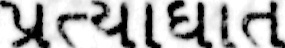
પ્રત્યાઘાત
